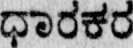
ಧಾರಕರ
